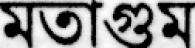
মতাগুম
